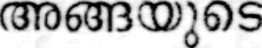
അങ്ങയുടെ
